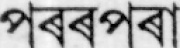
পৰৰপৰা
